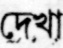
দেখা
